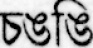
চঙঙি
